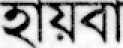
হায়বা
